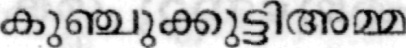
കുഞ്ചുക്കുട്ടിഅമ്മ
